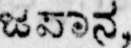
ಜಪಾನ,
